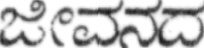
ಜೀವನದ
